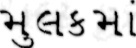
મુલકમાં
